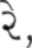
રે,
